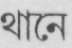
থানে
